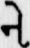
ને
